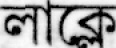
লাক্লে
